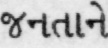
જનતાને
